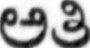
ಅತಿ
